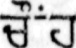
ਚੌਂਹ
